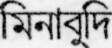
মিনাবুদি
